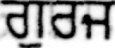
ਗੁਰਜ
